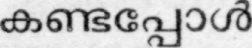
കണ്ടപ്പോള്‍
